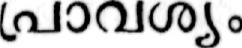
പ്രാവശ്യം
